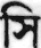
সি
